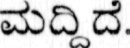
ಮದ್ದಿದೆ.
